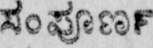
ಸಂಪೂರ್ಣ
